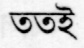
ততই
